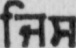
ਜਿਸ
